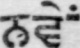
ਨਵੇਂ
